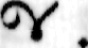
જ.
